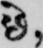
છે,
